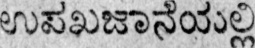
ಉಪಖಜಾನೆಯಲ್ಲಿ
